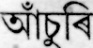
আঁচুৰি
